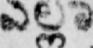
ಎಲ್ಲಾ
